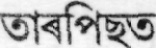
তাৰপিছত
